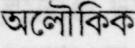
অলৌকিক
